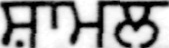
ਸ਼ਾਮਲ
